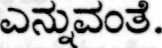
ಎನ್ನುವಂತೆ.
